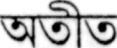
অতীত
